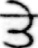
ਤੇ
